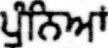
ਪੁੰਨਿਆਂ
